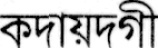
কদায়দগী
